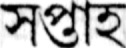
সপ্তাহ
